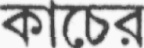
কাচের
